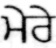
ਮੇਰੇ
